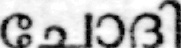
ചോദി
